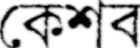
কেশব
